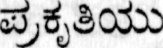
ಪ್ರಕೃತಿಯು
